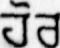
ਹੋਰ
